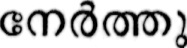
നേര്‍ത്തു
